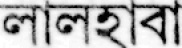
লালহাবা
